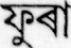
ফুৰা
